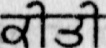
ਕੀਤੀ
